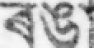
ৰঙা
